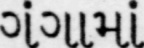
ગંગામાં
